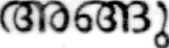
അങ്ങു
